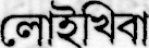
লোইখিবা
